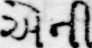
એની
